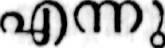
എന്നു
